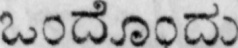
ಒಂದೊಂದು
